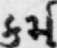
કર્મ
